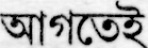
আগতেই
